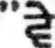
''ਵੇ
